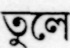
তুলে
